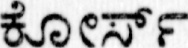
ಕೋರ್ಸ್
